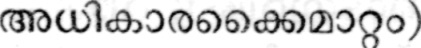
അധികാരക്കൈമാറ്റം)
